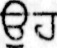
ਉਹ
